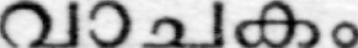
വാചകം
